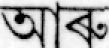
আৰু
